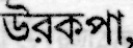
উরকপা,
